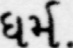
ધર્મ.
